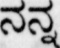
ನನ್ನ
